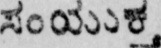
ಸಂಯುಕ್ತ
